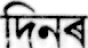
দিনৰ
